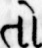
તો
